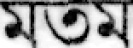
মতম
